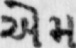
એમ
